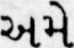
અમે
